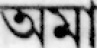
অমা
